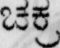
ಚಕ್ರ
